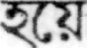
হয়ে
